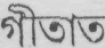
গীতাত
